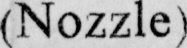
(Nozzle)
